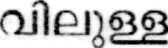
വിലുള്ള
